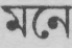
মনে
